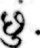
છું.
